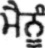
ਮੈਨੂੰ
